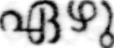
ഏഴു
